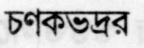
চণকভদ্রর
